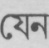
যেন
